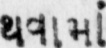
થવામાં
